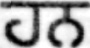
ਹਨ
